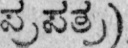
ಪ್ರಪತ್ರ)
